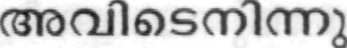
അവിടെനിന്നു
